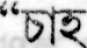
"চাহ
